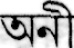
অনী
